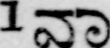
1ವಾ
